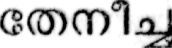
തേനീച്ച
